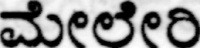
ಮೇಲೇರಿ
